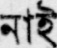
নাই
